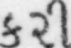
કરી
